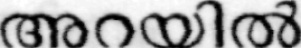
അറയില്‍
